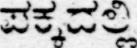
ಪಕ್ಕದಲ್ಲಿ
